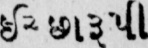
ઇચ્છારૂપી
